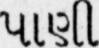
પાણી
